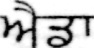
ਐਡਾ
